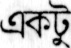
একটু
